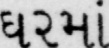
ઘરમાં
